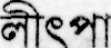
লীৎপা
